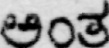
ಅಂತ
